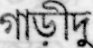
গাড়ীদু
